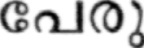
പേരു
